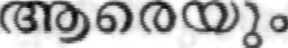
ആരെയും
